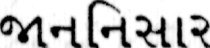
જાનનિસાર
